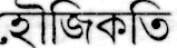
হৌজিকতি
